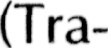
(Tra
